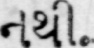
નથી.
